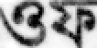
ওফ
